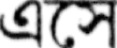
এসে
